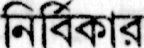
নির্বিকার
